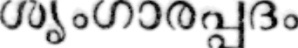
ശൃംഗാരപ്പദം
